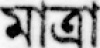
মাত্রা
